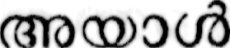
അയാള്‍
